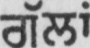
ਗੱਲਾਂ
